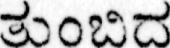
ತುಂಬಿದ
